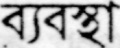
ব্যবস্থা
